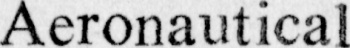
Aeronautical
